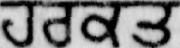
ਹਰਕਤ
